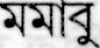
মমাবু
